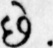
છે.
